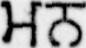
ਮਨ
